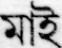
মাই
